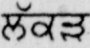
ਲੱਕੜ
